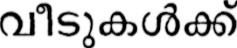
വീടുകള്‍ക്ക്
